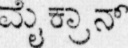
ಮೈಕ್ರಾನ್
